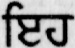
ਇਹ
